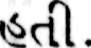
હતી.
